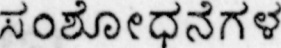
ಸಂಶೋಧನೆಗಳ
